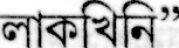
লাকখিনি”
